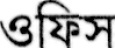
ওফিস
